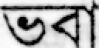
ভবা
